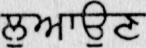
ਲੁਆਉਣ
